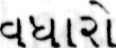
વધારો
